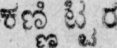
ಕಣ್ಣಿಟ್ಟಿರ
